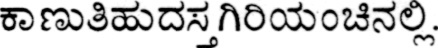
ಕಾಣುತಿಹುದಸ್ತಗಿರಿಯಂಚಿನಲ್ಲಿ.
